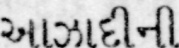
આઝાદીની
